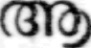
ആ
